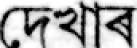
দেখাৰ
